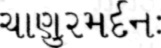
ચાણુરમર્દનઃ
